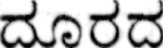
ದೊರದ
